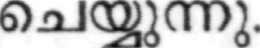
ചെയ്യുന്നു.
